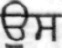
ਉਸ
